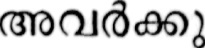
അവര്‍ക്കു
